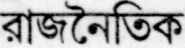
রাজনৈতিক
